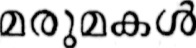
മരുമകള്‍
